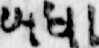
બધા
